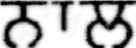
ਨਾਲ
